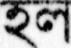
হল
